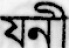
যনী
